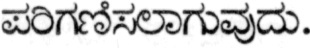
ಪರಿಗಣಿಸಲಾಗುವುದು.
